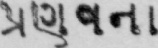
પ્રણયના
